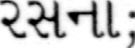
રસના;
